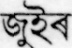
জুইৰ
